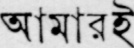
আমারই
